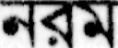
নরম
